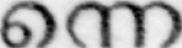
ന്നെ
